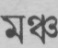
মঞ্চ
